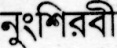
নুংশিরবীট
